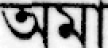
অমা
